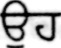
ਉਹ
